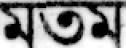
মতম
